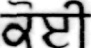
ਕੋਈ
